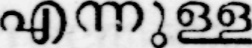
എന്നുള്ള
